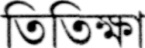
তিতিক্ষা
